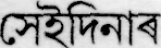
সেইদিনাৰ
